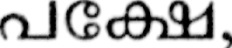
പക്ഷേ,
